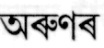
অৰুণৰ
